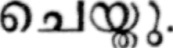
ചെയ്തു.
